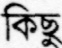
কিছু
